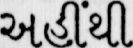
અહીંથી
